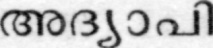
അദ്യാപി
